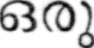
ഒരു
